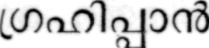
ഗ്രഹിപ്പാന്‍
